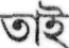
তাই
